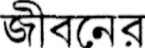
জীবনের
